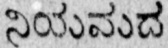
ನಿಯಮದ
